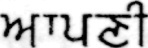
ਆਪਣੀ
